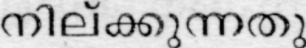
നില്ക്കുന്നതു
